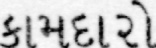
કામદારો
